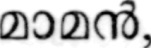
മാമന്‍,
